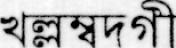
খল্লম্বদগী
